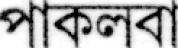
পাকলবা
